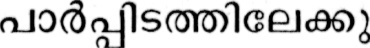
പാര്‍പ്പിടത്തിലേക്കു
